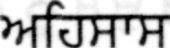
ਅਹਿਸਾਸ
